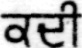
ਕਦੀ
